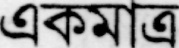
একমাত্র
